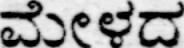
ಮೇಳದ
